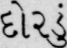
દોરડું
